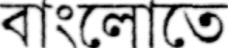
বাংলোতে
